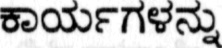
ಕಾರ್ಯಗಳನ್ನು
